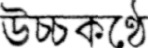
উচ্চকণ্ঠে
